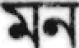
মন
